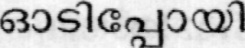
ഓടിപ്പോയി
